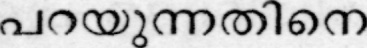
പറയുന്നതിനെ
